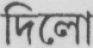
দিলো
